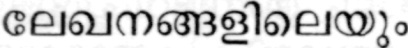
ലേഖനങ്ങളിലെയും
